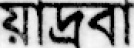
য়াদ্রবা
